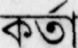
কর্তা
